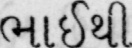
ભાઈથી
